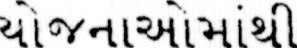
યોજનાઓમાંથી
